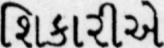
શિકારીએ
